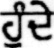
ਹੁੰਦੇ
